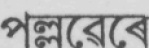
পল্লৱেৰে
